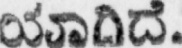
ಯಾಗಿದೆ.
